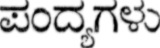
ಪಂದ್ಯಗಳು
